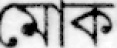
মোক
